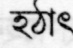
হঠাত্
